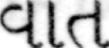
વાત
